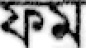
ফম
